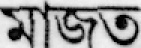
মাজত
